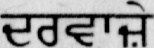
ਦਰਵਾਜ਼ੇ
